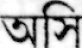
অসি
